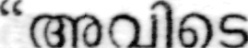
“അവിടെ
